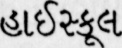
હાઈસ્કૂલ
